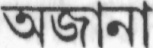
অজানা
